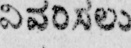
ವಿವರಿಸಲು
